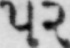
પર
